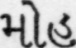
મોહ
